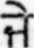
ਜੇ
